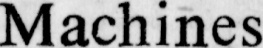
Machines
